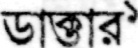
ডাক্তার১
